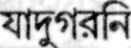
যাদুগরনি
